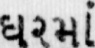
ઘરમાં
